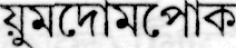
য়ুমদোমপোক
